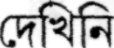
দেখিনি
